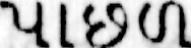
પાછળ
